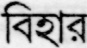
বিহার
